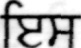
ਇਸ
